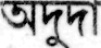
অদুদা
